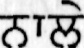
ਨਾਲੇ
